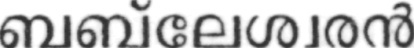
ബബ്ലേശ്വരന്‍
